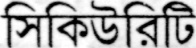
সিকিউরিটি
